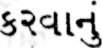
કરવાનું
